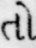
તો
